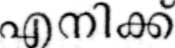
എനിക്ക്
